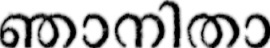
ഞാനിതാ
